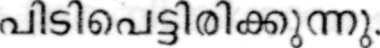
പിടിപെട്ടിരിക്കുന്നു.
